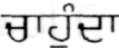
ਚਾਹੁੰਦਾ
